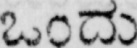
ಒಂದು
